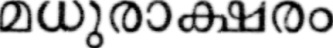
മധുരാക്ഷരം
